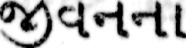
જીવનના
